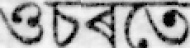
ওচৰতে
